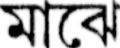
মাঝে
